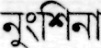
নুংশিনা
